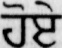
ਹੋਏ
